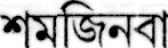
শমজিনবা
